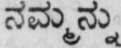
ನಮ್ಮನ್ನು
